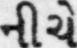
નીચે
